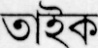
তাইক
